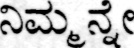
ನಿಮ್ಮನ್ನೇ
